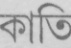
কাতি
